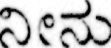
ನೀನು
